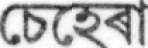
চেহেৰা
